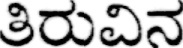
ತಿರುವಿನ
